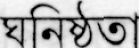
ঘনিষ্ঠতা
